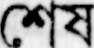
শেষ
